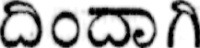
ದಿಂದಾಗಿ
